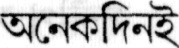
অনেকদিনই
